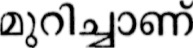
മുറിച്ചാണ്
